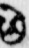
છે
